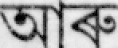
আৰু
